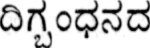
ದಿಗ್ಬಂಧನದ
